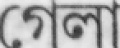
গেলা
